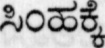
ಸಿಂಹಕ್ಕೆ
